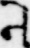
ને
